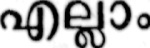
എല്ലാം
